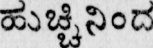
ಹುಚ್ಚಿನಿಂದ
